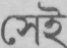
সেই
